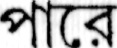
পারে
